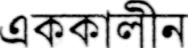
এককালীন
